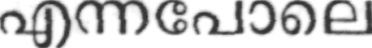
എന്നപോലെ
